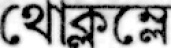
থোক্লম্লে
